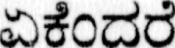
ಏಕೆಂದರೆ
